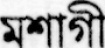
মশাগী
